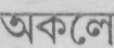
অকলে
